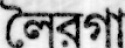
লৈরগা
